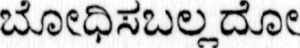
ಬೋಧಿಸಬಲ್ಲದೋ
